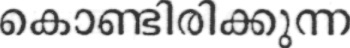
കൊണ്ടിരിക്കുന്ന
